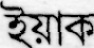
ইয়াক
